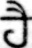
ਹੈ
